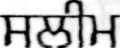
ਸਲੀਮ
